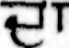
ਦਾ
